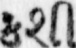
કશી
